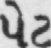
પેટ
